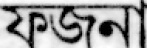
ফজনা
